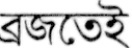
ব্রজতেই
